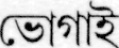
ভোগাই
